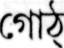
গোঠ্
